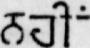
ਨਹੀਂ
